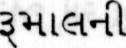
રૂમાલની
